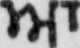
ਆ
